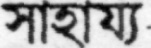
সাহায্য
